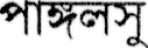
পাঙ্গলসু
